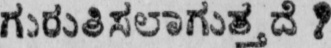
ಗುರುತಿಸಲಾಗುತ್ತದೆ?
